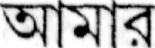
আমার
